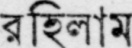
রহিলাম
